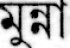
মুন্না
